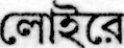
লোইরে
